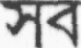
সব
